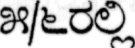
೫/೬ರಲ್ಲಿ
